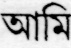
আমি
